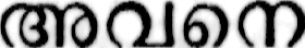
അവനെ
